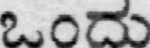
ಒ೦ದು
